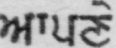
ਆਪਣੇ
